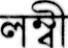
লম্বী
